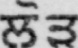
ਲੋੜ
